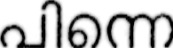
പിന്നെ
